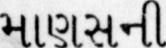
માણસની
